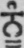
ਨੂੰ
